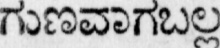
ಗುಣವಾಗಬಲ್ಲ
